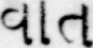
વાત
